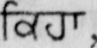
ਕਿਹਾ,
